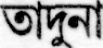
তাদুনা
